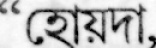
“হোয়দা,
